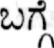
ಬಗ್ಗೆ
